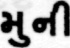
મુની
